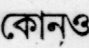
কোনও
